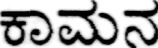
ಕಾಮನ
